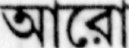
আরো
